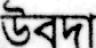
উবদা
